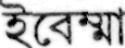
ইবেম্মা
